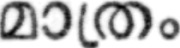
മാത്രം
